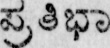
ಪ್ರತಿಭಾ
